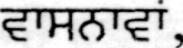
ਵਾਸਨਾਵਾਂ,
